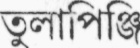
তুলাপিঞ্জি
